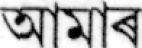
আমাৰ
